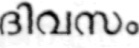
ദിവസം
